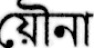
য়ৌনা
